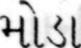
મોડા
